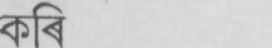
কৰি
